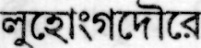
লুহোংগদৌরে
